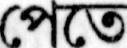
পেতে
